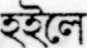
হইলে
